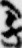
કે
